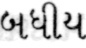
બધીય
